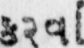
કરવાં
